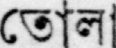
তোলা
